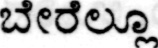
ಬೇರೆಲ್ಲೂ
